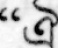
“ঐ
